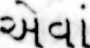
એવાં
